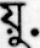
য়ু.
